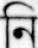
নি
